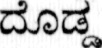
ದೊಡ್ಡ
